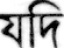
যদি
